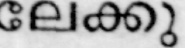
ലേക്കു
